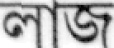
লাজ
